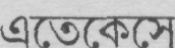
এতেকেসে
